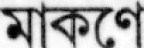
মাকণে
